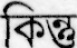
কিন্তু
